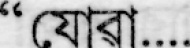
"যোৱা....
